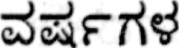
ವರ್ಷಗಳ
